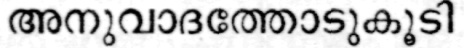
അനുവാദത്തോടുകൂടി
